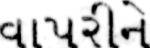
વાપરીને
